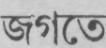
জগতে
